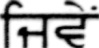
ਜਿਵੇਂ
